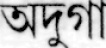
অদুগা
